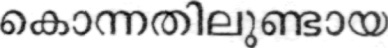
കൊന്നതിലുണ്ടായ
